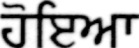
ਹੋਇਆ
